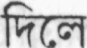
দিলে
